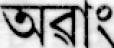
অৱাং
